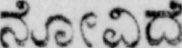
ನೋವಿದೆ
